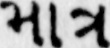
માત્ર
